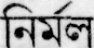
নির্মল
